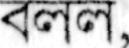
বলল,
